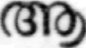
ആ
